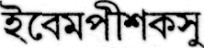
ইবেমপীশকসু
